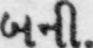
બની.
